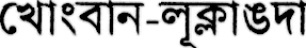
খোংবান-লুক্লাঙদা
